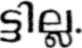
ട്ടില്ല.
